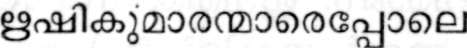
ഋഷികുമാരന്മാരെപ്പോലെ
